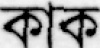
কাক
